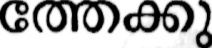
ത്തേക്കു
